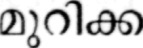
മുറിക്ക
